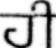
ਹੀ
